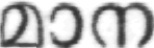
മാന
